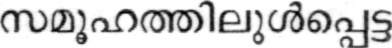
സമൂഹത്തിലുള്‍പ്പെട്ട
